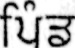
ਪਿੰਡ
